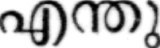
എന്തു
